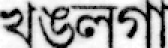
খঙলগা
